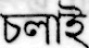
চলাই
